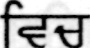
ਵਿਚ
